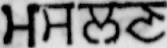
ਮਸਲਣ
